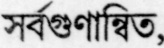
সর্বগুণান্বিত,
